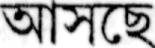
আসছে
